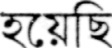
হয়েছি
